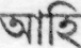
আহি
